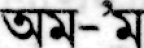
য়েংলুসিরা
